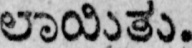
ಲಾಯಿತು.
